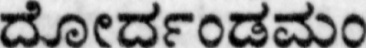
ದೋರ್ದಂಡಮಂ
